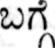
ಬಗ್ಗೆ
